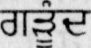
ਗੜੂੰਦ
